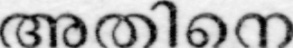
അതിനെ
